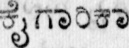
ಕೈಗಾರಿಕಾ
